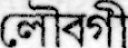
লৌবগী
